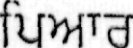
ਪਿਆਰ
